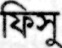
ফিসু
